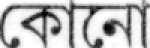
কোনো
